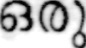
ഒരു
